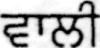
ਵਾਲੀ
